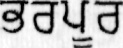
ਭਰਪੂਰ
